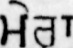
ਮੇਰਾ
